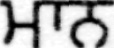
ਮਾਨ
